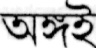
অঙ্গই
